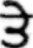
ਤੇ
